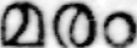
മരം
